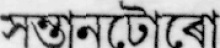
সন্তানটোৰো
